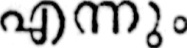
എന്നും
